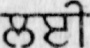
ਲਈ
